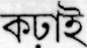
কঢ়াই
